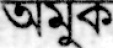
অমুক
